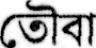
তৌবা
